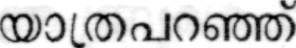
യാത്രപറഞ്ഞ്
